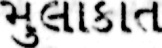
મુલાકાત
